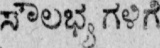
ಸೌಲಭ್ಯಗಳಿಗೆ
